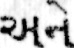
અને
